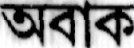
অবাক
